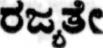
ರಜ್ಯತೇ
